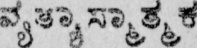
ವ್ಯತ್ಯಾಸ್ಮಾತ್ಮಕ
